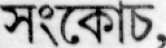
সংকোচ,
